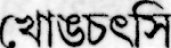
খোঙচৎসি
